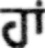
ਹਾਂ
